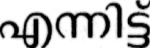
എന്നിട്ട്
